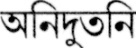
অনিদুতনি
